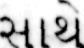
સાથે
